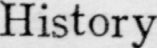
History
